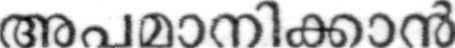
അപമാനിക്കാന്‍
